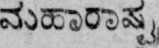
ಮಹಾರಾಷ್ಟ್ರ
